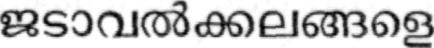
ജടാവല്‍ക്കലങ്ങളെ
